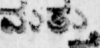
ಮತ್ತು
